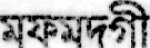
মফমদগী
